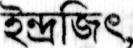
ইন্দ্রজিৎ,
